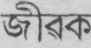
জীৱক
